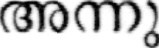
അന്നു
